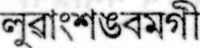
লুৱাংশঙবমগী
